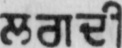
ਲਗਦੀ
